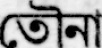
তৌনা
